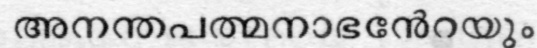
അനന്തപത്മനാഭന്റേയും
